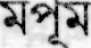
মপূম
